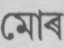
মোৰ
